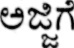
ಅಜ್ಜಿಗೆ
